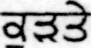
ਕੁੜਤੇ
